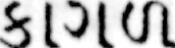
કાગળ
